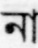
না
